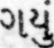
ગયું
